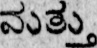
ಮತ್ತು
